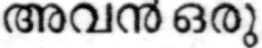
അവന്‍ഒരു
